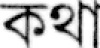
কথা
